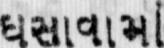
ઘસાવામાં
